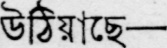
উঠিয়াছে—
